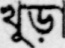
খুড়া
